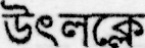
উৎলক্লে
